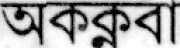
অকক্নবা
